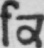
ਕਿ
